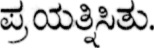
ಪ್ರಯತ್ನಿಸಿತು.
